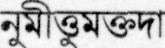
নুমীত্তুমক্তদা
